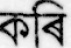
কৰি
